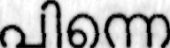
പിന്നെ
